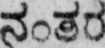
ನಂತರ
